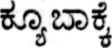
ಕ್ಯೂಬಾಕ್ಕೆ
